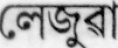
লেজুৱা
